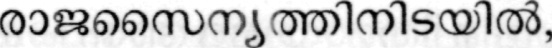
രാജസൈന്യത്തിനിടയില്‍,
